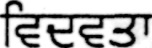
ਵਿਦਵਤਾ
